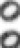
ঃ
